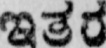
ಇತರ
